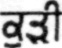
ਕੁੜੀ
